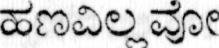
ಹಣವಿಲ್ಲವೋ
